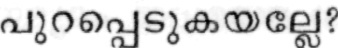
പുറപ്പെടുകയല്ലേ?
